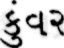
કુંવર
